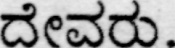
ದೇವರು.
